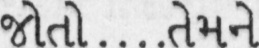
જોતો....તેમને
